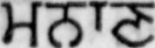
ਮਨਾਣ
